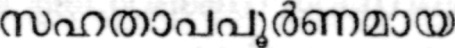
സഹതാപപൂര്‍ണമായ
